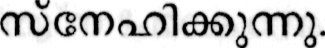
സ്നേഹിക്കുന്നു.
